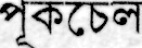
পূকচেল
